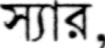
স্যার,
